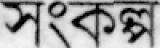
সংকল্প
